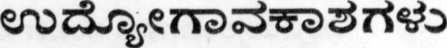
ಉದ್ಯೋಗಾವಕಾಶಗಳು
